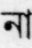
না
